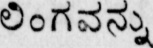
ಲಿಂಗವನ್ನು
